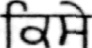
ਕਿਸੇ
